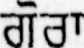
ਗੋਰਾ
